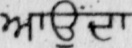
ਆਉਂਦਾ
